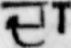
ਦਾ
